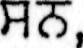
ਸਨ,
